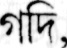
গদি,
